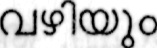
വഴിയും
